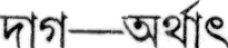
দাগ-অর্থাৎ
